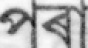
পৰা
